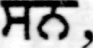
ਸਨ,
